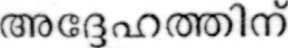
അദ്ദേഹത്തിന്
